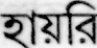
হায়রি
